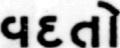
વદતો
